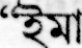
“ইমা
